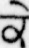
ਕੇ
